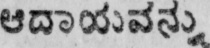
ಆದಾಯವನ್ನು
